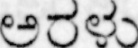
ಅರಳು
